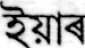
ইয়াৰ
